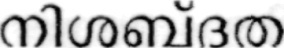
നിശബ്ദത
